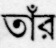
তাঁর
